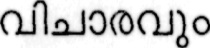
വിചാരവും
